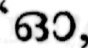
'ഓ,
